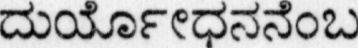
ದುರ್ಯೋಧನನೆಂಬ
